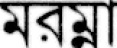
মরম্না
